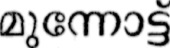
മുന്നോട്ട്
